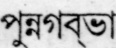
পুন্নগব্ভা
